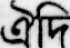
ঐদি
